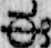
ಈ
